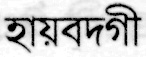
হায়বদগী
